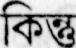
কিন্তু
